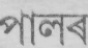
পালৰ
